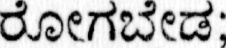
ರೋಗಬೇಡ;
